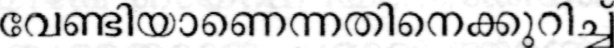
വേണ്ടിയാണെന്നതിനെക്കുറിച്ച്
